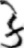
કે
